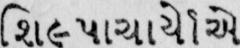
શિલ્પાચાર્યોએ
